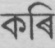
কৰি
